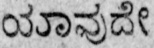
ಯಾವುದೇ
